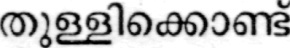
തുള്ളിക്കൊണ്ട്
